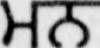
ਮਨ
